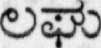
ಲಘು
